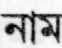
নাম
